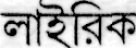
লাইরিক
